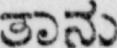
ತಾನು
